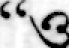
“ও
